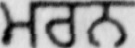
ਮਰਨ
